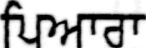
ਪਿਆਰਾ
